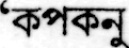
‘কপকনু
